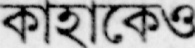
কাহাকেও
